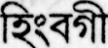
হিংবগী
